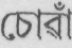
চোৱাঁ
